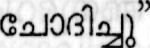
ചോദിച്ചു"
